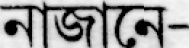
নাজানে-
